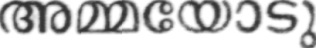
അമ്മയോടു
